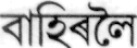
বাহিৰলৈ
